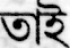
তাই
